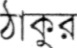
ঠাকুর
